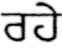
ਰਹੇ
